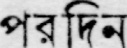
পরদিন
